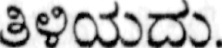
ತಿಳಿಯದು.
